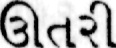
ઊતરી
